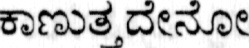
ಕಾಣುತ್ತದೇನೋ
